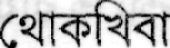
থোকখিবা
